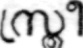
സ്ത്രീ
